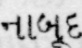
નાબૂદ
